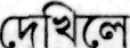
দেখিলে
